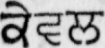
ਕੇਵਲ
